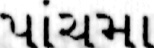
પાંચમા
